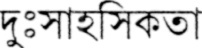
দুঃসাহসিকতা
